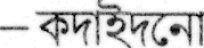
-কদাইদনো
